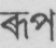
ৰূপ
